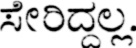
ಸೇರಿದ್ದಲ್ಲ.
